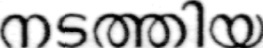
നടത്തിയ
